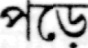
পড়ে
